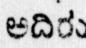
ಅದಿರು
